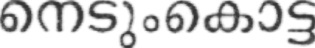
നെടുംകൊട്ട
